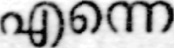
എന്നെ
